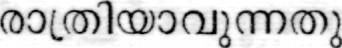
രാത്രിയാവുന്നതു
